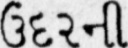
ઉંદરની
